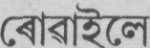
ৰোৱাইলে
